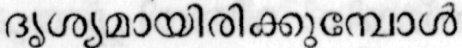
ദൃശ്യമായിരിക്കുമ്പോള്‍
